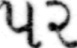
પર
